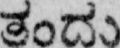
ತಂದು
